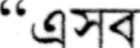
“এসব
